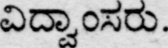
ವಿದ್ವಾಂಸರು.
